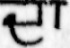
ਦਾ
